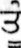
ਤੂੰ
